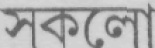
সকলো
